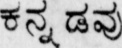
ಕನ್ನಡವು
